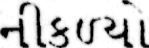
નીકળ્યો
